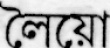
লৈয়ো
